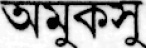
অমুকসু
